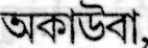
অকাউবা,
